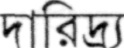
দারিদ্র্য
